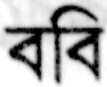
ববি
